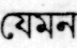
যেমন
